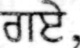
ਗਏ,
